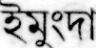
ইমুংদা
